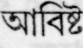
আবিষ্ট
